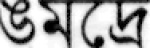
ঙমদ্রে
